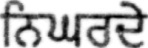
ਨਿਘਰਦੇ
